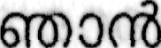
ഞാന്‍
